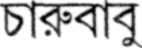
চারুবাবু
